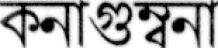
কনাগুম্বনা
